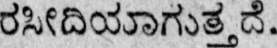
ರಸೀದಿಯಾಗುತ್ತದೆ.
